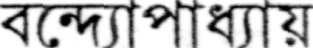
বন্দ্যোপাধ্যায়
